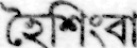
হৈশিংবা
